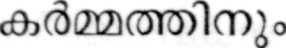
കര്‍മ്മത്തിനും
